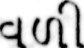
વળી
